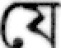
যে
